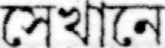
সেখানে
